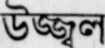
উজ্জ্বল
